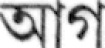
আগ
